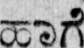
ಹಾಗೆ
